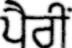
ਪੈਰੀਂ
